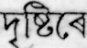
দৃষ্টিৰে
